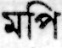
মপি
